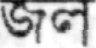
জল
